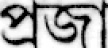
প্রজা
